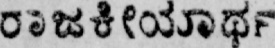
ರಾಜಕೀಯಾರ್ಥ
